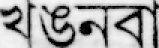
খঙনবা
